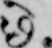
છે.
